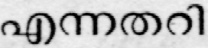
എന്നതറി
